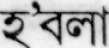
হ'বলা
